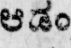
ಆಡ೦
